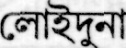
লোইদুনা
